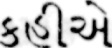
કહીએ
